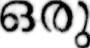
ഒരു
